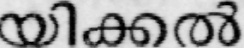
യിക്കല്‍
